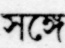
সঙ্গে
